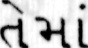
તેમાં
